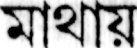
মাথায়
